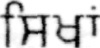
ਸਿਖਾਂ
